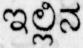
ಇಲ್ಲಿನ
